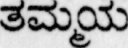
ತಮ್ಮಯ
